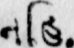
નહિ.
